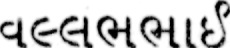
વલ્લભભાઈ
